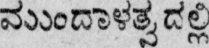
ಮುಂದಾಳತ್ವದಲ್ಲಿ
